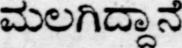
ಮಲಗಿದ್ದಾನೆ
